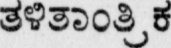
ತಳಿತಾಂತ್ರಿಕ
